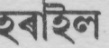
হৰাইল
